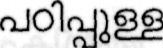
പഠിപ്പുള്ള
